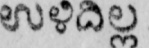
ಉಳಿದಿಲ್ಲ.
